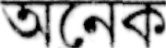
অনেক
